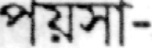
পয়সা-
